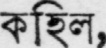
কহিল,
